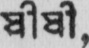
ਬੀਬੀ,
